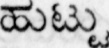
ಹುಟ್ಟು
